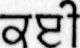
ਕਈ
